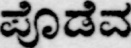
ಪೊಡೆವ
